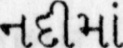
નદીમાં
